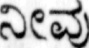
ನೀವು
